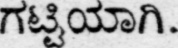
ಗಟ್ಟಿಯಾಗಿ.
